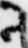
ને
